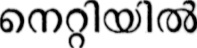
നെറ്റിയില്‍
